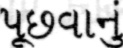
પૂછવાનું
